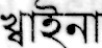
খ্বাইনা
